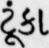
ટૂંકા
